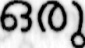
ഒരു
